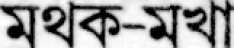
মথক-মখা
